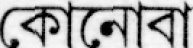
কোনোবা
